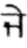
ਜੇ
